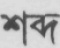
শব্দ
